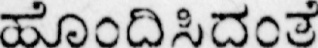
ಹೊಂದಿಸಿದಂತೆ
